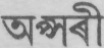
অপ্সৰী
